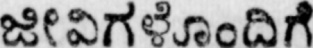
ಜೀವಿಗಳೊಂದಿಗೆ
